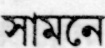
সামনে
